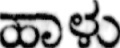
ಹಾಳು
